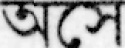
অসে
